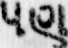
પણ
